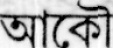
আকৌ
